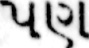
પણ
